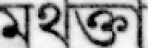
মথক্তা
